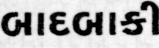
બાદબાકી
